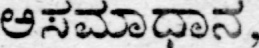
ಅಸಮಾಧಾನ,
